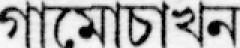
গামোচাখন
